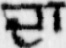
ਦਾ
